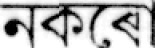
নকৰো
